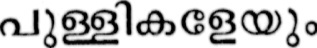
പുള്ളികളേയും
